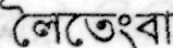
লৈতেংবা
